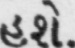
હશે.
